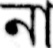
না
